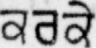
ਕਰਕੇ
